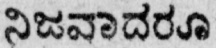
ನಿಜವಾದರೂ
